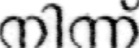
നിന്ന്
